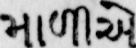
માળીએ
